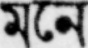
মনে
